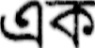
এক
